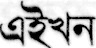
এইখন
